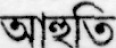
আহুতি
